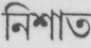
নিশাত
